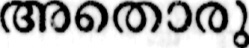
അതൊരു
